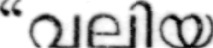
“വലിയ
